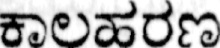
ಕಾಲಹರಣ
